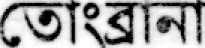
তোংব্রানা
